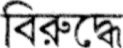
বিরুদ্ধে
